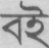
বই
